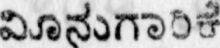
ಮೀನುಗಾರಿಕೆ
